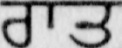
ਰਾਤ
